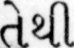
તેથી
